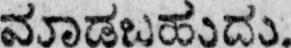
ಮಾಡಬಹುದು.
